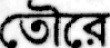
তৌরে
